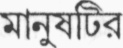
মানুষটির
